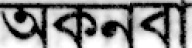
অকনবা
